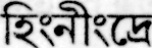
হিংনীংদ্রে
